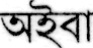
অইবা
